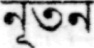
নূতন
